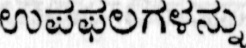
ಉಪಫಲಗಳನ್ನು
